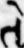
તે
